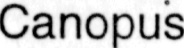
canopus
